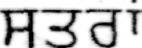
ਸਤਰਾਂ
